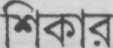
শিকার
